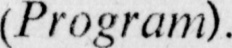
(Program).
